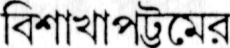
বিশাখাপট্টমের
